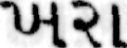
ખરા
